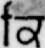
ਕਿ
